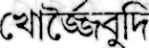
খোর্জ্জৈবুদি
